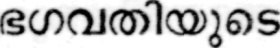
ഭഗവതിയുടെ
